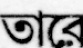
তারে
